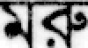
মরু
